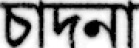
চাদনা
